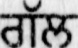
ਗੱਲ
